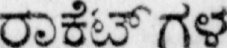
ರಾಕೆಟ್‌ಗಳ
